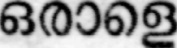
ഒരാളെ
